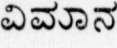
ವಿಮಾನ
